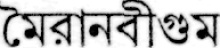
মৈরানবীগুম
